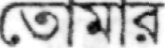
তোমার
